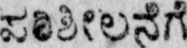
ಪರಿಶೀಲನೆಗೆ
